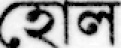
হোল
